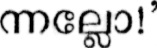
ന്നല്ലോ!'
